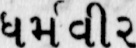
ધર્મવીર
